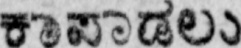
ಕಾಪಾಡಲು
